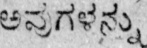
ಅವುಗಳನ್ನು
